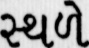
સ્થળે
